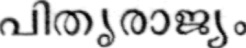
പിതൃരാജ്യം
